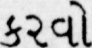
કરવો
